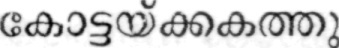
കോട്ടയ്ക്കകത്തു
